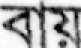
বায়
